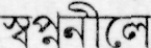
স্বপ্ননীলে
